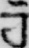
ਹੋ
